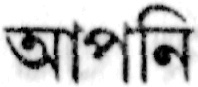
আপনি
